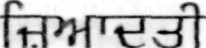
ਜ਼ਿਆਦਤੀ
